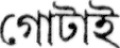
গোটাই
